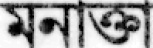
মনাক্তা
